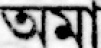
অমা
